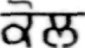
ਕੋਲ
